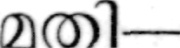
മതി-
